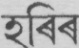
হৰিৰ
